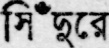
সিঁদুরে
